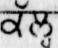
ਕੱਲ੍ਹ
